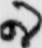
જે
